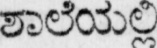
ಶಾಲೆಯಲ್ಲಿ
